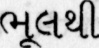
ભૂલથી
